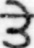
ਤੇ
